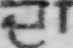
ਦਾ
